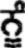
ਨੂੰ
